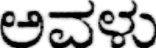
ಅವಳು
